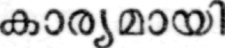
കാര്യമായി
